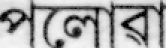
পলোৱা
